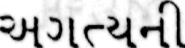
અગત્યની
